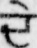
ਦੇ
